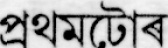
প্রথমটোৰ
